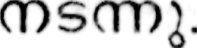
നടന്നു.
